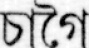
চাগৈ
